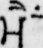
ਮੈਂ
